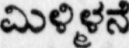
ಮಿಳ್ಮಿಳನೆ
